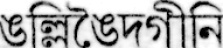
ঙল্লিঙৈদগীনি
